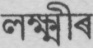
লক্ষ্মীৰ
